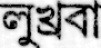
লুখ্রবা
